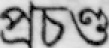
প্রচণ্ড
